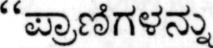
“ಪ್ರಾಣಿಗಳನ್ನು
